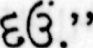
દઉં."
